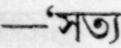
–‘সত্য
